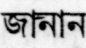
জানান
